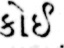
કોઈ
